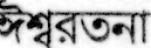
ঈশ্বরতনা
